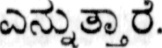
ಎನ್ನುತ್ತಾರೆ.
